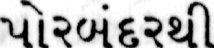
પોરબંદરથી
